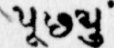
પૂછ્યું
